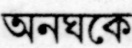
অনঘকে
